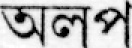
অলপ
